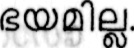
ഭയമില്ല.
